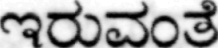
ಇರುವಂತೆ
